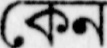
কেন
